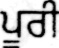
ਪੂਰੀ
